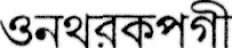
ওনথোরকপগী
